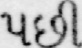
પછી
